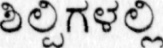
ಶಿಲ್ಪಿಗಳಲ್ಲಿ
